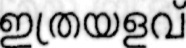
ഇത്രയളവ്
